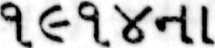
૧૯૧૪ના
